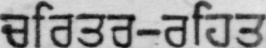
ਚਰਿਤਰ-ਰਹਿਤ
